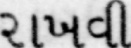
રાખવી
